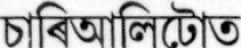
চাৰিআলিটোত
